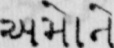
અમોને
